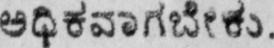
ಅಧಿಕವಾಗಬೇಕು.
